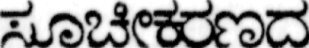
ಸೂಚೀಕರಣದ
